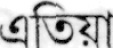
এতিয়া
